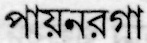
পায়নরগা
